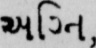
અગ્નિ,
